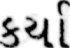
કર્યા
